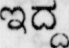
ಇದ್ದ
